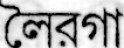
লৈরগা
